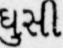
ઘુસી
